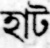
হাট
